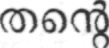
തന്റെ
